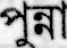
পুন্না
